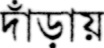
দাঁড়ায়
